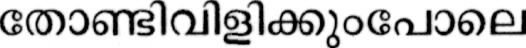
തോണ്ടിവിളിക്കുംപോലെ
